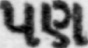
પણ
